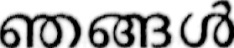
ഞങ്ങള്‍
